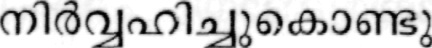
നിര്‍വ്വഹിച്ചുകൊണ്ടു
